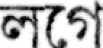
লগে
